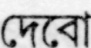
দেবো
